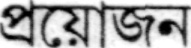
প্রয়োজন
